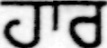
ਹਾਰ
